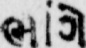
ભાંગે
